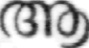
ആ
